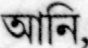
আনি,
